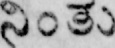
ನಿಂತು
